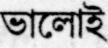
ভালোই
